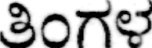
ತಿಂಗಳ
